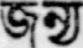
জন্য
